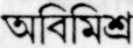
অবিমিশ্র
